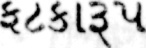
ફટકારૂપ
